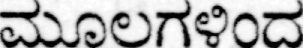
ಮೂಲಗಳಿಂದ
